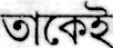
তাকেই
